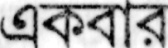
একবার
